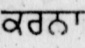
ਕਰਨਾ
